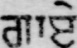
ਗਾਏ
